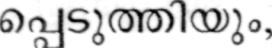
പ്പെടുത്തിയും,
